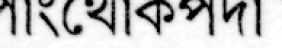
পাংথোকপদা
